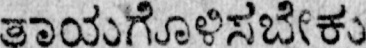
ತಾಯಗೊಳಿಸಬೇಕು
